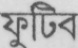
ফুটিব
